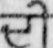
ਦੀ
